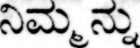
ನಿಮ್ಮನ್ನು
